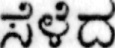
ಸೆಳೆದ
